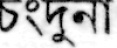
চংদুনা
